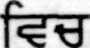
ਵਿਚ
